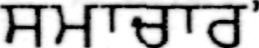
ਸਮਾਚਾਰ'
